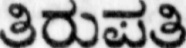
ತಿರುಪತಿ
